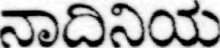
ನಾದಿನಿಯ
